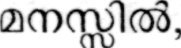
മനസ്സില്‍,
